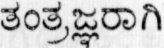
ತಂತ್ರಜ್ಞರಾಗಿ
